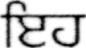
ਇਹ
